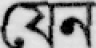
যেন
